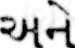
અને
